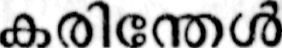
കരിന്തേള്‍
